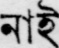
নাই
